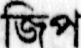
জিপ
